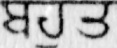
ਬਹੁਤ
